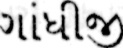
ગાંધીજી
